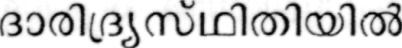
ദാരിദ്ര്യസ്ഥിതിയില്‍
